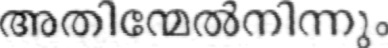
അതിന്മേല്‍നിന്നും
